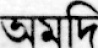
অমদি
